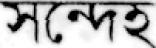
সন্দেহ
